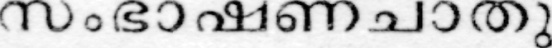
സംഭാഷണചാതു
